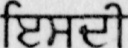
ਇਸਦੀ
